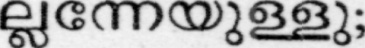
ല്ലന്നേയുള്ളു;
